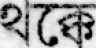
থক্কে
